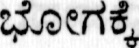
ಭೋಗಕ್ಕೆ
